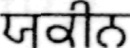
ਯਕੀਨ
